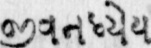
જીવનધ્યેય
